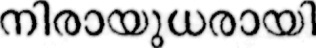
നിരായുധരായി
